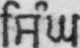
ਸਿੰਘ
